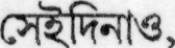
সেইদিনাও,
